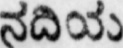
ನದಿಯ
